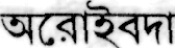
অরোইবদা
